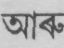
আৰু
